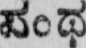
ಪಂಥ
